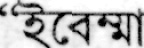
“ইবেম্মা
